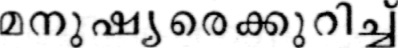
മനുഷ്യരെക്കുറിച്ച്
